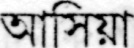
আসিয়া
